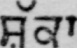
ਸ਼ੱਕਾ
